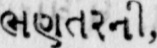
ભણતરની,
